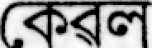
কেৱল
